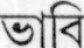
ভাবি
